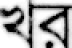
খর
